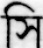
সি
